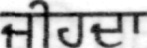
ਜੀਹਦਾ
